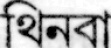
থিনবা
